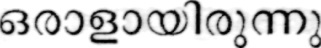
ഒരാളായിരുന്നു
